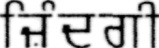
ਜ਼ਿੰਦਗੀ
